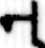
ન
